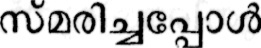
സ്മരിച്ചപ്പോള്‍
